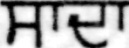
ਸਾਦਾ
